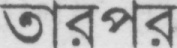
তারপর
